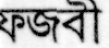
ফজবী
